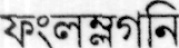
ফংলম্লগনি
